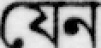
যেন
